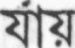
যায়
